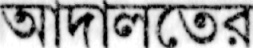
আদালতের
